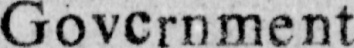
Governmentಯ
